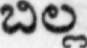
ಬಿಲ್ಲ
